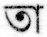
তা
